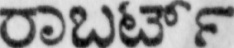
ರಾಬರ್ಟ್
